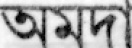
অমদা
